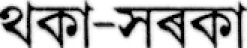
থকা-সৰকা
